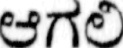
ಆಗಲಿ
